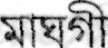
মাধগী
